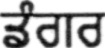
ਡੰਗਰ
